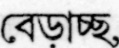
বেড়াচ্ছ,
